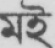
মই
